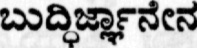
ಬುದ್ಧಿರ್ಜ್ಞಾನೇನ
